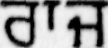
ਰਾਜ
